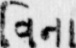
વિના
